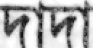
দাদা
